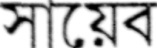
সায়েব
